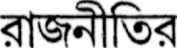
রাজনীতির
